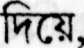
দিয়ে,
